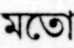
মতো
